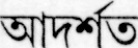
আদর্শত
